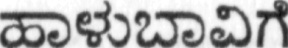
ಹಾಳುಬಾವಿಗೆ
